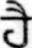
ਹੈ
